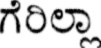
ಗೆರಿಲ್ಲಾ
